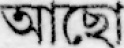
আছো
